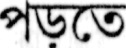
পড়তে
